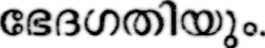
ഭേദഗതിയും.
